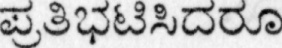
ಪ್ರತಿಭಟಿಸಿದರೂ
